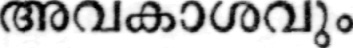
അവകാശവും
